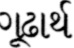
ગૂઢાર્થ
